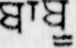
ਬਾਬੂ
